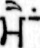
ਮੈਂ
